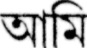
আমি
